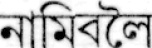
নামিবলৈ
